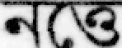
নত্তে
